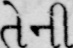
તેની
